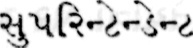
સુપરિન્ટેન્ડેન્ટ
